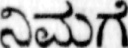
ನಿಮಗೆ
